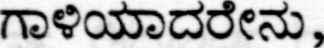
ಗಾಳಿಯಾದರೇನು,
